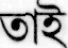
তাই
